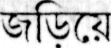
জড়িয়ে
